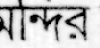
মন্দির
